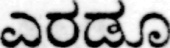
ಎರಡೂ
